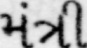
મંત્રી
